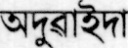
অদুৱাইদা
